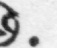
છે.
